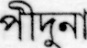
পীদুনা
